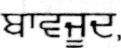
ਬਾਵਜੂਦ,
